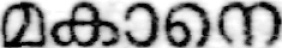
മകാനെ
